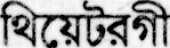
থিয়েটরগী
